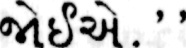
જોઈએ."
